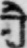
ਹੈ
